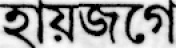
হায়জগে
